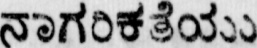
ನಾಗರಿಕತೆಯು
